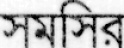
সমসির
